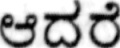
ಆದರೆ
